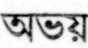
অভয়
